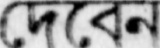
দেবেন
